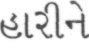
હારીને
